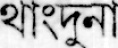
থাংদুনা
